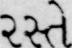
રસ્તે
